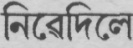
নিৱেদিলে
